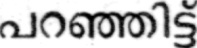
പറഞ്ഞിട്ട്
